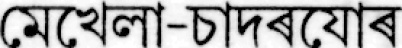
মেখেলা-চাদৰযোৰ
